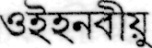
ওইহনবীয়ু
